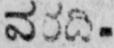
ವರದಿ.
